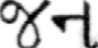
જન
